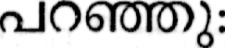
പറഞ്ഞു:
